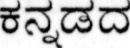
ಕನ್ನಡದ
